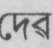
দেৱ
